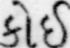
કોઈ
